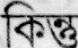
কিন্তু
